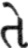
તે
